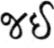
જઈ
